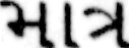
માત્ર
